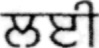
ਲਈ
